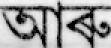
আৰু
